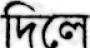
দিলে
